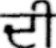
ਦੀ
